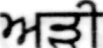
ਅੜੀ
